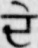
ਦੇ
